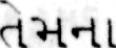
તેમના
